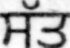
ਸੱਤ
